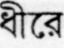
ধীরে
